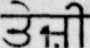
ਤੇਜ਼ੀ
